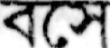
বসে
